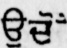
ਉਦੋਂ
